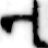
ન
